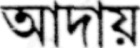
আদায়
